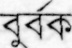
বুর্বক
